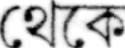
থেকে
